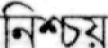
নিশ্চয়
